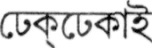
ঢেক্‌ঢেকাই
